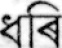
ধৰি
